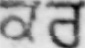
ਕਰ
